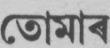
তোমাৰ
